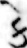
કે
